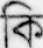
কি
